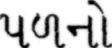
પળનો
